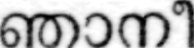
ഞാനീ
